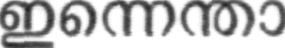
ഇന്നെന്താ
